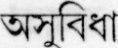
অসুবিধা
